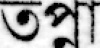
তপ্না
